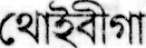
থোইবীগা
